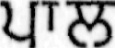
ਪਾਲ
